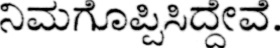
ನಿಮಗೊಪ್ಪಿಸಿದ್ದೇವೆ.
